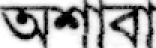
অশাবা
